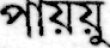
পায়য়ু
